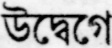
উদ্বেগে
